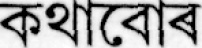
কথাবোৰ
